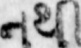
નથી
